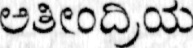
ಅತೀಂದ್ರಿಯ
